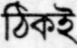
ঠিকই
